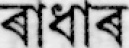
ৰাধাৰ
